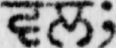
ਵਲ;
